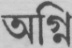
অগ্নি
